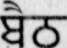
ਬੈਠ
